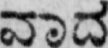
ವಾದ
